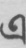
এ
